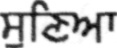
ਸੁਣਿਆ
